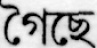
গৈছে
